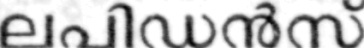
ലപിഡന്‍സ്
